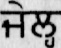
ਜੇਲ੍ਹ
